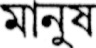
মানুষ
